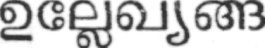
ഉല്ലേഖ്യങ്ങ
